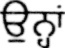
ਉਨ੍ਹਾਂ
